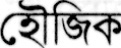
হৌজিক
